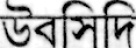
উবসিদি
